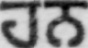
ਹਨ
